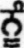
ਨੂੰ
